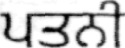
ਪਤਨੀ
